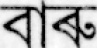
বাৰু
